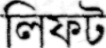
লিফট
